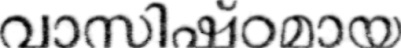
വാസിഷ്ഠമായ
